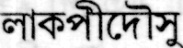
লাকপীদৌসু
